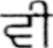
ਵੀ
